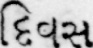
દિવસ
